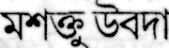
মশক্তু
